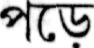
পড়ে
